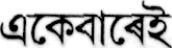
একেবাৰেই
